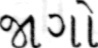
જાગો
